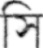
সি
